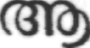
ആ
